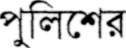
পুলিশের
